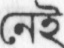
নেই
